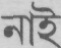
নাই
